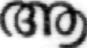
ആ
